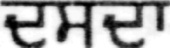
ਦਸਦਾ
